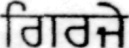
ਗਿਰਜੇ
